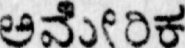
ಅಮೇರಿಕ
